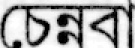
চেন্নবা
